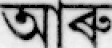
আৰু
